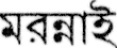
মরন্নাই
